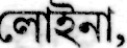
লোইনা,
